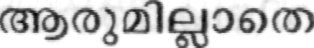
ആരുമില്ലാതെ
